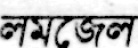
লমজেল
